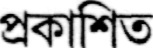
প্রকাশিত
